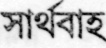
সার্থবাহ
